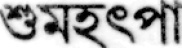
শুমহৎপা
